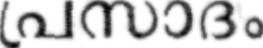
പ്രസാദം
